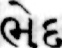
ભેદ
